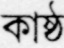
কাষ্ঠ
